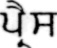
ਪ੍ਰੈਸ
